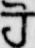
ਹੋ
